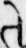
તે
